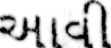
આવી
